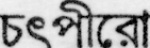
চৎপীরো
